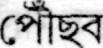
পৌঁছব
